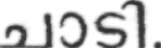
ചാടി.
